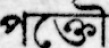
পক্তৌ
